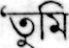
'তুমি
